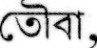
তৌবা,
